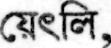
য়েৎলি,
